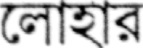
লোহার
